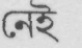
নেই
